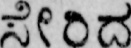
ಸೇರಿದ
